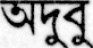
অদুবু
